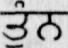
ਤੁੰਨ
